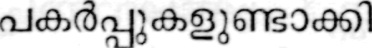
പകര്‍പ്പുകളുണ്ടാക്കി
